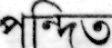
পন্দিত
